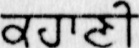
ਕਹਾਣੀ
